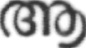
ആ
